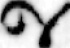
જ
